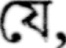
যে,
